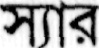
স্যার
